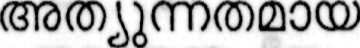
അത്യുന്നതമായ
